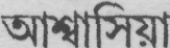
আশ্বাসিয়া
